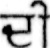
ਦੀ
